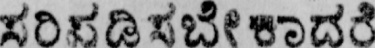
ಸರಿಪಡಿಸಬೇಕಾದರೆ
